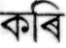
কৰি
